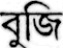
বুজি
